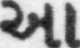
આ
